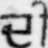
ਦੀ
